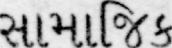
સામાજિક
